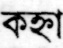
কহ্না
